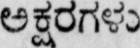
ಅಕ್ಷರಗಳು
